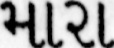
મારા
